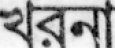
খরনা
